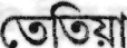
তেতিয়া
